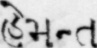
હેમન્ત
